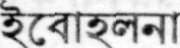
ইবোহলনা
